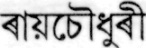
ৰায়চৌধুৰী
